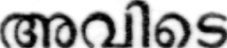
അവിടെ
